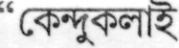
"কেন্দুকলাই
